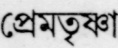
প্রেমতৃষ্ণা
